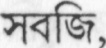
সবজি,
